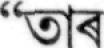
"তাৰ
